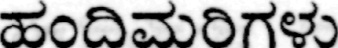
ಹಂದಿಮರಿಗಳು
